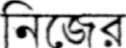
নিজের
